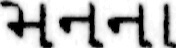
મનના
